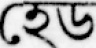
হেড
